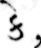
કે,
